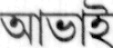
আভাই
